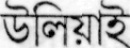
উলিয়াই
